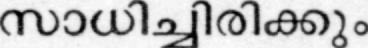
സാധിച്ചിരിക്കും
